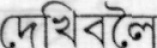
দেখিবলৈ
